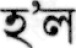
হ'ল
